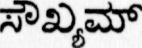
ಸೌಖ್ಯಮ್
